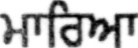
ਮਾਰਿਆ
